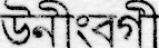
উনীংবগী
